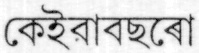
কেইবাবছৰো
